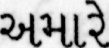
અમારે
